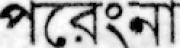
পরেংনা
